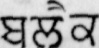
ਬਲੈਕ
